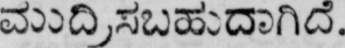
ಮುದ್ರಿಸಬಹುದಾಗಿದೆ.
